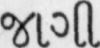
જાગી
